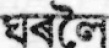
ঘৰলৈ
